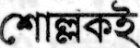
শোল্লকই
